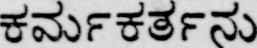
ಕರ್ಮಕರ್ತನು
